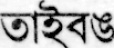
তাইবঙ
